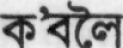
ক'বলৈ
